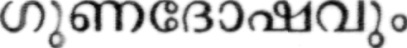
ഗുണദോഷവും
